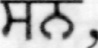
ਸਨ,
